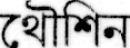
থৌশিন
